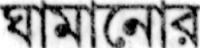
ঘামানোর
